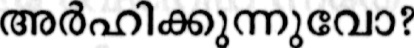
അര്‍ഹിക്കുന്നുവോ?
